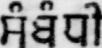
ਸੰਬੰਧੀ
